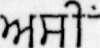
ਅਸੀਂ
